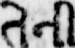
તેની
